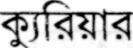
ক্যুরিয়ার
